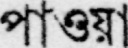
পাওয়া
